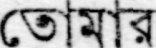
তোমার
